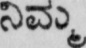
ನಿಮ್ಮ
